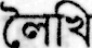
লৈখি
